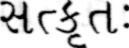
સત્કૃતઃ
